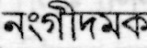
নংগীদমক
